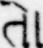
તો
